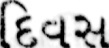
દિવસ
